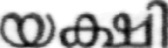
യക്ഷി
